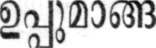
ഉപ്പുമാങ്ങ
